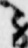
કે
